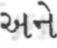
અને
